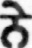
ਨੇ
